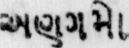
અણગમો
